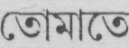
তোমাতে
